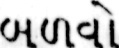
બળવો
